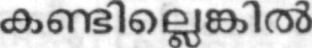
കണ്ടില്ലെങ്കില്‍
